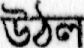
উঠল
